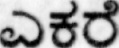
ಎಕರೆ
